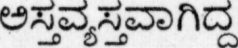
ಅಸ್ತವ್ಯಸ್ತವಾಗಿದ್ದ
